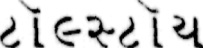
ટૉલ્સટૉય
